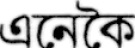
এনেকৈ
